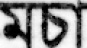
মচা
